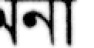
মনা
